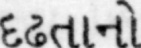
દઢતાનો
